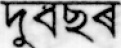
দুবছৰ
